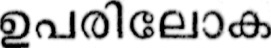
ഉപരിലോക
